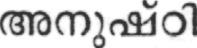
അനുഷ്ഠി
